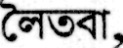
লৈতবা,
